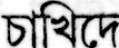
চাখিদে
